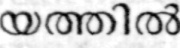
യത്തില്‍
